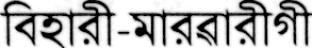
বিহারী-মারৱারীগী
